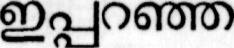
ഇപ്പറഞ്ഞ
